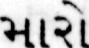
મારો
